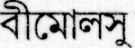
বীমোলসু
